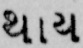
થાય
